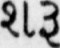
શરૂ
